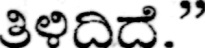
ತಿಳಿದಿದೆ."
